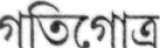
গতিগোত্র
